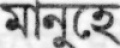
মানুহে
